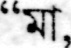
“মা,
